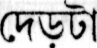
দেড়টা
